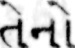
તેનો
